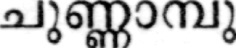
ചുണ്ണാമ്പു
